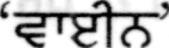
'ਵਾਈਨ'
